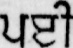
ਪਈ
